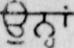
ਉਨ੍ਹਾਂ
